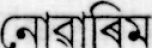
নোৱাৰিম
